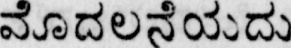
ಮೊದಲನೆಯದು
